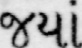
જ્યાં
